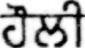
ਹੌਲੀ
